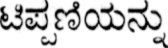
ಟಿಪ್ಪಣಿಯನ್ನು
